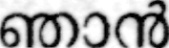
ഞാന്‍
